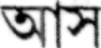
আস
